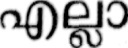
എല്ലാ
